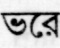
ভরে
